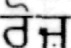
ਰੋਜ਼
